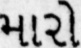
મારો
